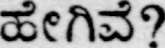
ಹೇಗಿವೆ?
